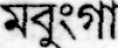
মবুংগা
